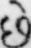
છે
